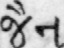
જૈન
